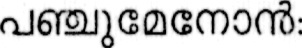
പഞ്ചുമേനോന്‍:
